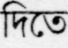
দিতে
